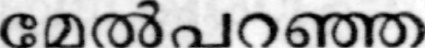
മേല്‍പറഞ്ഞ
